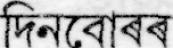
দিনবোৰৰ
